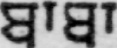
ਬਾਬਾ
